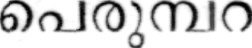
പെരുമ്പറ
